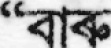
"বাৰু
